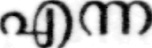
എന്ന
